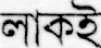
লাকই
